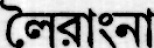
লৈরাংনা
